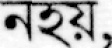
নহয়,
